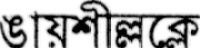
ঙায়শীল্লক্লে
